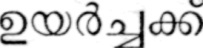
ഉയര്‍ച്ചക്ക്
